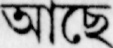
আছে
